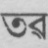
তৱ
